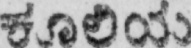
ಕೂಲಿಯ
